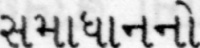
સમાધાનનો
